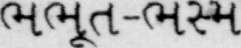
ભભૂત-ભસ્મ
